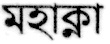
মহাক্না
